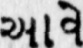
આવે
